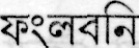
ফংলবনি
